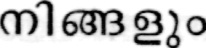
നിങ്ങളും
